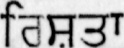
ਰਿਸ਼ਤਾ
